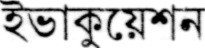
ইভাকুয়েশন
